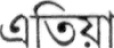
এতিয়া
